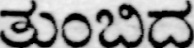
ತುಂಬಿದ
